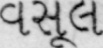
વસૂલ
